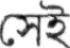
সেই
